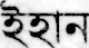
ইহান
